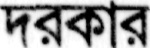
দরকার
